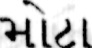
મોટા
